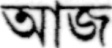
আজ
